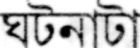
ঘটনাটা
